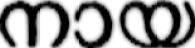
നായ
